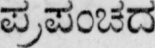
ಪ್ರಪಂಚದ
